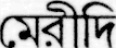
মেরীদি
